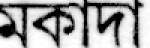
মকাদা
